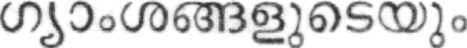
ഗ്യാംശങ്ങളുടെയും
